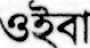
ওইবা
